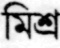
মিশ্র
